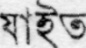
যাইত
